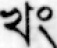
খং
